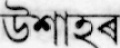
উশাহৰ
